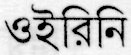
ওইরিনি
